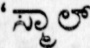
‘ಸ್ಮಾಲ್
